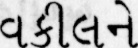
વકીલને
